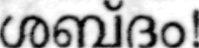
ശബ്ദം!
